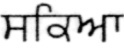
ਸਕਿਆ
